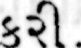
કરી.
